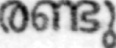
രണ്ടു
